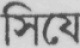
সিযে
